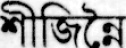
শীজিন্নৈ
